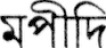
মপীদি
